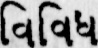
વિવિધ
